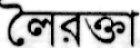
লৈরক্তা
